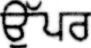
ਉੱਪਰ
